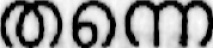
തന്നെ
